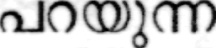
പറയുന്ന
